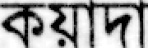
কয়াদা
